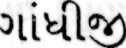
ગાંધીજી
